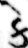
કે
